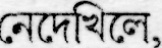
নেদেখিলে,
